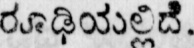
ರೂಢಿಯಲ್ಲಿದೆ.
